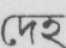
দেহ
